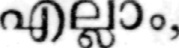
എല്ലാം,
